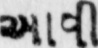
આવી
